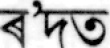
ৰ'দত
